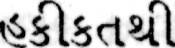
હકીકતથી
